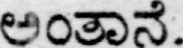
ಅಂತಾನೆ.
